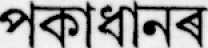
পকাধানৰ
